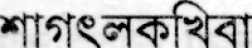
শাগৎলকখিবা
